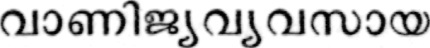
വാണിജ്യവ്യവസായ
